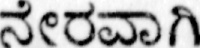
ನೇರವಾಗಿ
